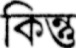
কিন্তু
